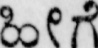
ಹೀಗೆ
